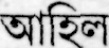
আহিল
